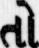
તો
